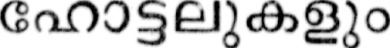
ഹോട്ടലുകളും
